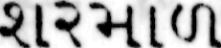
શરમાળ
